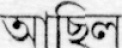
আছিল
